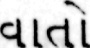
વાતો
